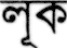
লূক
